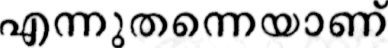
എന്നുതന്നെയാണ്
